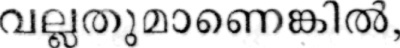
വല്ലതുമാണെങ്കില്‍,
